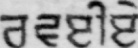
ਰਵਈਏ
